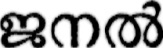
ജനല്‍
